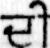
ਦੀ
